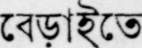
বেড়াইতে
